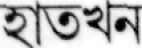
হাতখন
